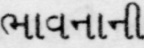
ભાવનાની
